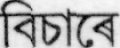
বিচাৰে
